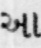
આ
